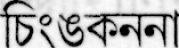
চিংঙকননা
